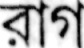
রাগ
